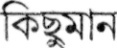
কিছুমান
